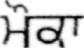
ਮੌਕਾ
